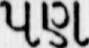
પણ
